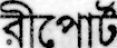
রীপোর্ট
